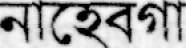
নাহেবগা
